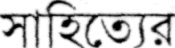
সাহিত্যের
